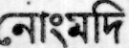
নোংমদি
